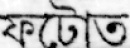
ফটোত
